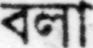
বলা
